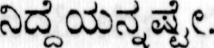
ನಿದ್ದೆಯನ್ನಷ್ಟೇ.
